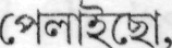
পেলাইছো,
